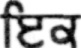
ਇਕ
